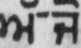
ਅੱਜੋ
